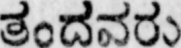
ತಂದವರು
